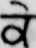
ਕੇ
